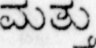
ಮತ್ತು
